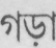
গড়া
